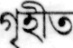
গৃহীত
